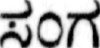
ಸಂಗ
